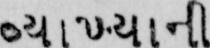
વ્યાખ્યાની
